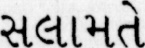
સલામતે
